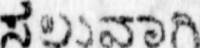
ಸಲುವಾಗಿ
